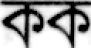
কক
